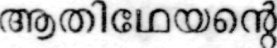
ആതിഥേയന്റെ
